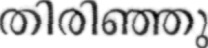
തിരിഞ്ഞു
